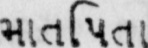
માતાપિતા
